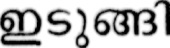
ഇടുങ്ങി
